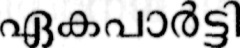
ഏകപാര്‍ട്ടി
